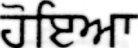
ਹੋਇਆ
